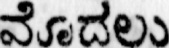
ಮೊದಲು
